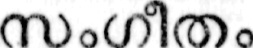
സംഗീതം
